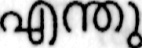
എന്തു
